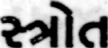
સ્ત્રોત
